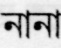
নানা
